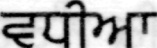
ਵਧੀਆ
